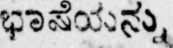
ಭಾಷೆಯನ್ನು
